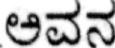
ಅವನ
